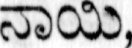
ನಾಯಿ,
